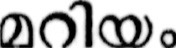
മറിയം
